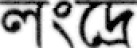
লংদ্রে
